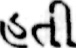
હતી
